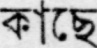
কাছে
